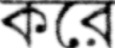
করে
